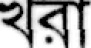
খরা
